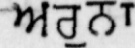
ਅਰੁਨਾ
